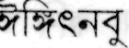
ঈঙ্গিৎনবু
